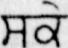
ਸਕੇ
